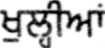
ਖੁਲ੍ਹੀਆਂ
